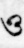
ও
